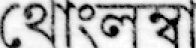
থোংলম্বা
